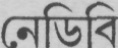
নেডিবি
